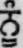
ਨੂੰ
